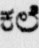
ಕಲೆ
